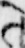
તે
